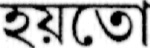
হয়তো
